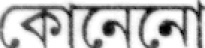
কোনেনো
